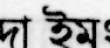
ঐখোয়
